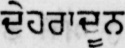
ਦੇਹਰਾਦੂਨ
